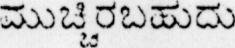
ಮುಚ್ಚಿರಬಹುದು
